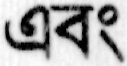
এরং
